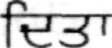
ਦਿਤਾ
